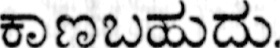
ಕಾಣಬಹುದು.
